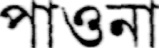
পাওনা
